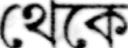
থেকে
